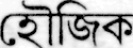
হৌজিক
